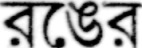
রঙের
